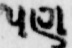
પણ
